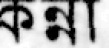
কন্না
